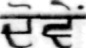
ਦੋਵੇਂ
